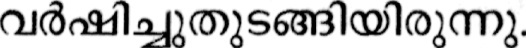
വര്‍ഷിച്ചുതുടങ്ങിയിരുന്നു.
